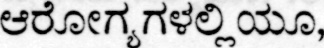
ಆರೋಗ್ಯಗಳಲ್ಲಿಯೂ,
